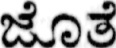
ಜೊತೆ
